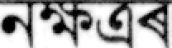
নক্ষত্রৰ
